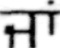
ਜਾਂ
